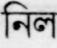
নিল
